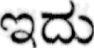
ಇದು
